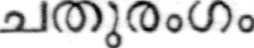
ചതുരംഗം
